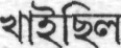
খাইছিল
